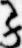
કે
